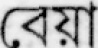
বেয়া
